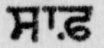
ਸਾਫ਼
